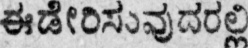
ಈಡೇರಿಸುವುದರಲ್ಲಿ
